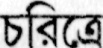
চরিত্রে
